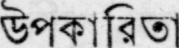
উপকারিতা
